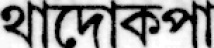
থাদোকপা
